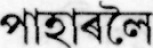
পাহাৰলৈ
